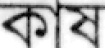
কাষ
